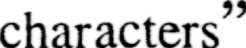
characters"
